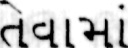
તેવામાં
